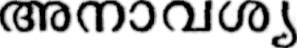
അനാവശ്യ
